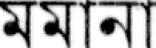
মমানা
